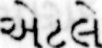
એટલે
